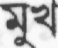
মুখ
